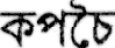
কপচৈ
